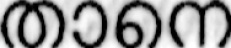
താനെ
